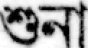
শুনা
